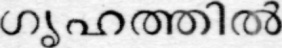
ഗൃഹത്തില്‍
